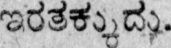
ಇರತಕ್ಕುದು.
